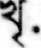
খৃ.
